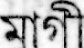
মাগী
